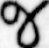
જ
